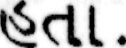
હતા.
